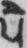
ਪੈ
